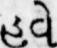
હવે
